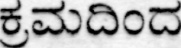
ಕ್ರಮದಿಂದ
